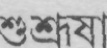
শুশ্ৰূষা
